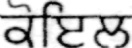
ਕੋਇਲ
